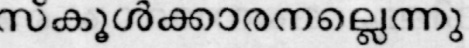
സ്കൂള്‍ക്കാരനല്ലെന്നു
